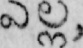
ಎಲ್ಲ,
